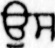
ਉਸ
